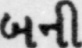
બની
